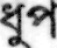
ধুপ
